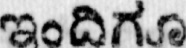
ಇಂದಿಗೂ
